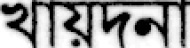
খায়দনা
